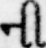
ની
